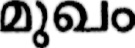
മുഖം
